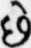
છે
